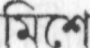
মিশে
